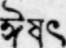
ঈষৎ
